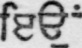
ਇਉਂ
